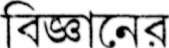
বিজ্ঞানের
